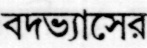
বদভ্যাসের
